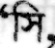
‘সি,
